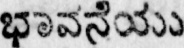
ಭಾವನೆಯು
